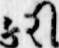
કરી
